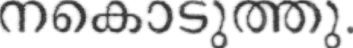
നകൊടുത്തു.
